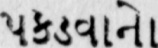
પકડવાનો
